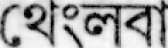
থেংলবা
